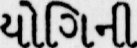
યોગિની
